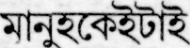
মানুহকেইটাই
